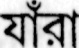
যাঁরা
